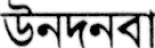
উনদনবা
